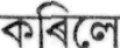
কৰিলে
